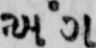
અંગ
